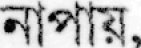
নাপায়,
